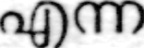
എന്ന
